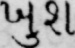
ખુશ
